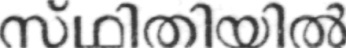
സ്ഥിതിയില്‍
